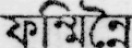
ফম্মিন্নৈ
